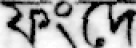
ফংদে
